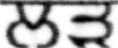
ਲੜ
